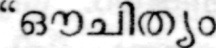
“ഔചിത്യം
